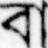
বা
